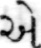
એ
